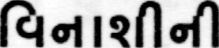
વિનાશીની
